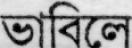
ভাবিলে
